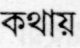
কথায়
